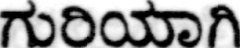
ಗುರಿಯಾಗಿ
